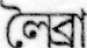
লৈব্রা
